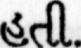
હતી.
